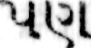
પણ
